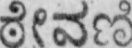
ಠೇವಣಿ
